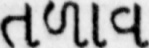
તળાવ
